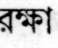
রক্ষা
